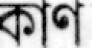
কাণ
